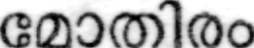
മോതിരം
